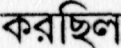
করছিল
